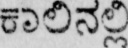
ಕಾಲಿನಲ್ಲಿ
